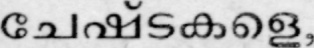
ചേഷ്ടകളെ,
